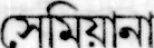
সেমিয়ানা
